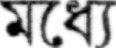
মধ্যে
